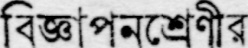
বিজ্ঞাপনশ্রেণীর
